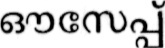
ഔസേപ്പ്
